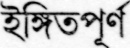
ইঙ্গিতপূর্ণ
